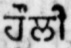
ਹੌਲੀ
